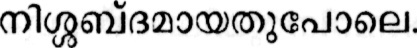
നിശ്ശബ്ദമായതുപോലെ.
